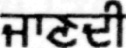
ਜਾਣਦੀ
